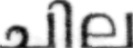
ചില
